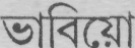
ভাবিয়ো
